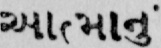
આત્માનું
